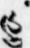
હું
